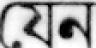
যেন
